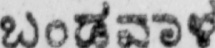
ಬಂಡವಾಳ
